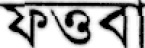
ফত্তবা
